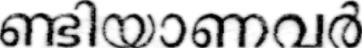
ണ്ടിയാണവര്‍
